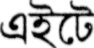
এইটে
